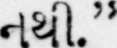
નથી."
